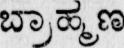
ಬ್ರಾಹ್ಮಣ
